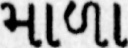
માળા
